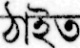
ঠাইত
